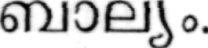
ബാല്യം.
